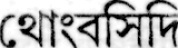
থোংবসিদি
